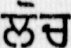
ਲੋਚ
